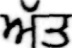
ਅੱਤ
